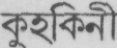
কুহকিনী
